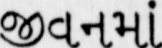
જીવનમાં
